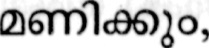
മണിക്കും,
